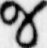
જ
